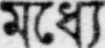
মধ্যে
